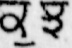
ਕੁਝ
